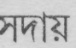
সদায়
